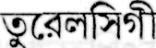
তুরেলসিগী
